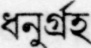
ধনুর্গ্রহ
